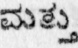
ಮತ್ತು
